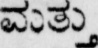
ಮತ್ತು
